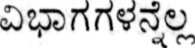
ವಿಭಾಗಗಳನ್ನೆಲ್ಲ
